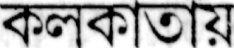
কলকাতায়
